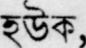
হউক,
